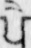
ਪੈ
